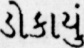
ડોકાયું
